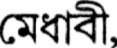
মেধাবী,
